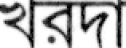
খরদা
